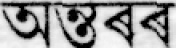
অন্তৰৰ
